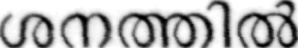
ശനത്തില്‍
